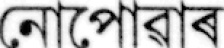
নোপোৱাৰ
